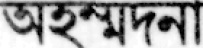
অহম্মদনা
